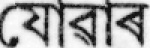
যোৱাৰ
